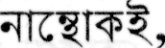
নান্থোকই,
